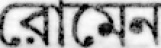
রোমেন
